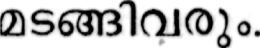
മടങ്ങിവരും.
